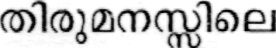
തിരുമനസ്സിലെ
